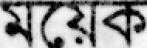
ময়েক
